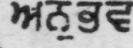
ਅਨੁਭਵ
